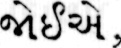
જોઈએ,
